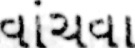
વાંચવા
